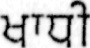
ਖਾਧੀ
